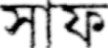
সাফ
